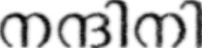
നന്ദിനി
